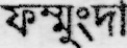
ফম্মূংদা
